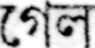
গেল
